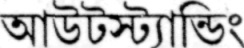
আউটস্ট্যান্ডিং
